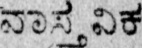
ವಾಸ್ತವಿಕ
